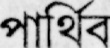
পার্থিব
